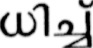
ധിച്ച്
